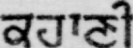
ਕਹਾਣੀ
